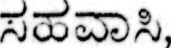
ಸಹವಾಸಿ,
